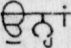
ਉਨ੍ਹਾਂ
